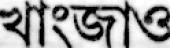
খাংজাও
